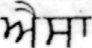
ਐਸਾ
